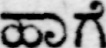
ಹಾಗೆ
